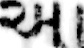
આ
